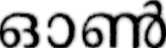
ഓണ്‍
